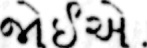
જોઈએ.
